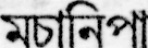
মচানিপা
